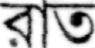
রাত
